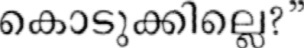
കൊടുക്കില്ലെ?"
